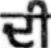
ਦੀ
